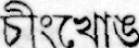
চীংখোং
